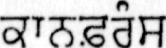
ਕਾਨਫ਼ਰੰਸ
